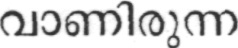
വാണിരുന്ന
